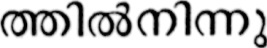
ത്തില്‍നിന്നു
